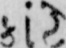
કાંટે
